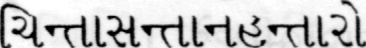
ચિન્તાસન્તાનહન્તારો
